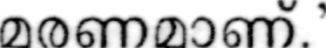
മരണമാണ്.’
